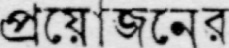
প্রয়োজনের
